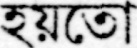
হয়তো
